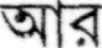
আর
